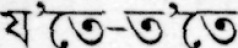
য'তে-ত'তে
